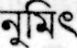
নুমিৎ
